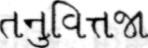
તનુવિત્તજા
